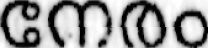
നേരം
